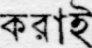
করাই
